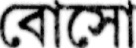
বোসো
